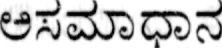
ಅಸಮಾಧಾನ
